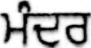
ਮੰਦਰ
